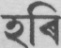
হৰি
